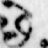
છે.
